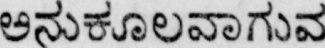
ಅನುಕೂಲವಾಗುವ
